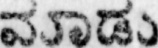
ಮಾಡು
